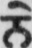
ਨੇ
